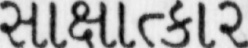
સાક્ષાત્કાર
